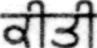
ਕੀਤੀ
